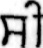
ਸੀ
